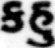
કહુ
